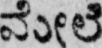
ಮೇಲೆ
